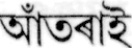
আঁতৰাই
